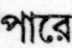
পারে
